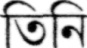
তিনি
